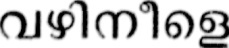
വഴിനീളെ
